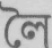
লৈ
